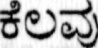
ಕೆಲವು
